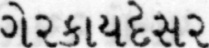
ગેરકાદેસર
